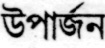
উপার্জন
